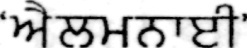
'ਐਲਮਨਾਈ'
